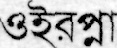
ওইরপ্না
